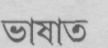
ভাষাত
